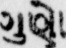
ગુણો
